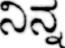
ನಿನ್ನ
